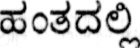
ಹಂತದಲ್ಲಿ
